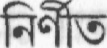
নির্ণীত
